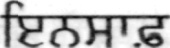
ਇਨਸਾਫ਼
